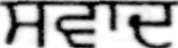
ਸਵਾਦ
